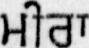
ਮੀਰਾ
